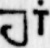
ਹਾਂ
